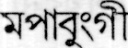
মপাবুংগী
